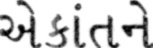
એકાંતને
